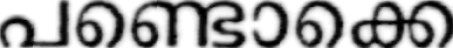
പണ്ടൊക്കെ
